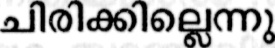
ചിരിക്കില്ലെന്നു
